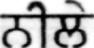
ਨੀਲੇ
